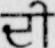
ਦੀ
